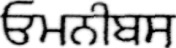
ਓਮਨੀਬਸ
